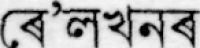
ৰে'লখনৰ
